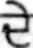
ਦੇ
